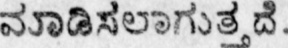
ಮಾಡಿಸಲಾಗುತ್ತದೆ.
